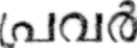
പ്രവര്‍
